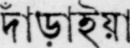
দাঁড়াইয়া
